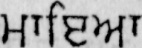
ਮਾਇਆ
